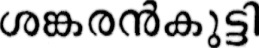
ശങ്കരന്‍കുട്ടി
